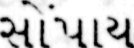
સોંપાય
